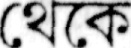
থেকে
